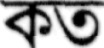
কত
